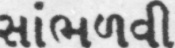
સાંભળવી
